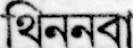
থিনবা
